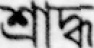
শ্রাদ্ধ
